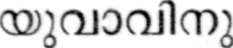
യുവാവിനു
